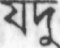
যদু
